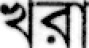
খরা
